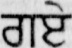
ਗਏ
